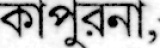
কাপুরনা,
